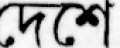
দেশে
